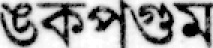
ঙকপগুম
